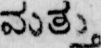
ಮತ್ತು
